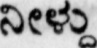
ನೀಳ್ದು
